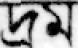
দ্রম
